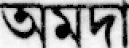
অমদা
